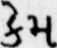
કેમ
